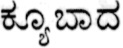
ಕ್ಯೂಬಾದ
